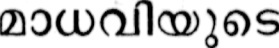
മാധവിയുടെ
